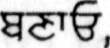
ਬਣਾਓ,
